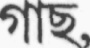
গাছ,
